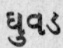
ઘુવડ
